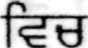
ਵਿਚ
